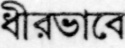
ধীরভাবে
